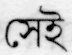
সেই
